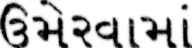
ઉમેરવામાં
